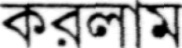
করলাম
